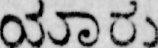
ಯಾರು
